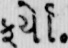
ફર્યો.
